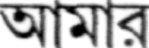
আমার
